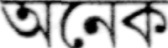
অনেক
